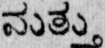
ಮತ್ತು
